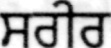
ਸਰੀਰ
